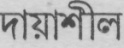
দায়াশীল
